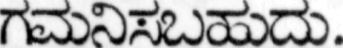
ಗಮನಿಸಬಹುದು.
